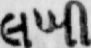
લખી
